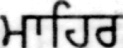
ਮਾਹਿਰ
